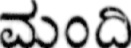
ಮಂದಿ
